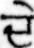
ਦੇ
